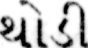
થોડી
